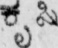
ಕೃಷಿ
